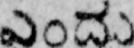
ಎಂದು
